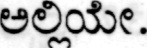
ಅಲ್ಲಿಯೇ.
